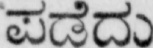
ಪಡೆದು
